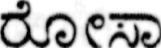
ರೋಸಾ
